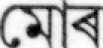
মোৰ
